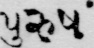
પુરુષં
